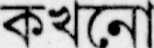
কখনো
